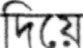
দিয়ে
